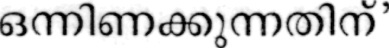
ഒന്നിണക്കുന്നതിന്'
